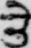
ਤੇ
